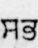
ਸਭ
